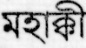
মহাক্কী
